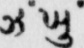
ઝંખું
